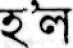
হ'ল
